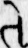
તે
